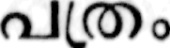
പത്രം
